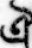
ঐ
